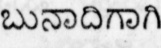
ಬುನಾದಿಗಾಗಿ
